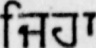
ਜਿਹਾ
